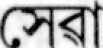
সেৱা
